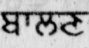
ਬਾਲਣ
